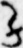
કે
